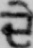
ਦੇ
